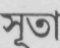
সূতা
